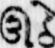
ઊઠે
